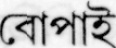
বোপাই
